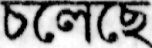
চলেছে
